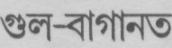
গুল-বাগানত
